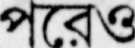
পরেও
